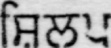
ਸ਼ਿਲਪ
